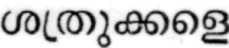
ശത്രുക്കളെ
